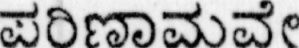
ಪರಿಣಾಮವೇ
